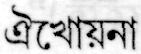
ঐখোয়না
